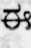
ಈ
